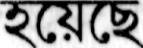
হয়েছে
